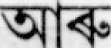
আৰু
